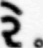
રે.
